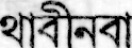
থাবীনবা
